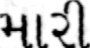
મારી
